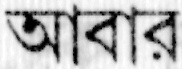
আবার
